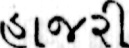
હાજરી
